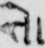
તો
